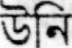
উনি
